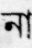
না
